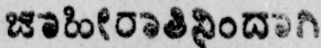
ಜಾಹೀರಾತಿನಿಂದಾಗಿ
